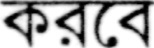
করবে
